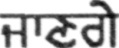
ਜਾਣਗੇ
